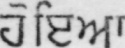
ਹੋਇਆ
